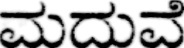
ಮದುವೆ
